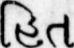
હિત
